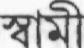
স্বামী
